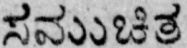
ಸಮುಚಿತ
